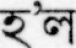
হ'ল
